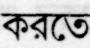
করতে
